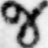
જ
